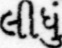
લીધું
